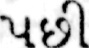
પછી
